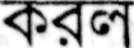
করল
